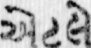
એટલે
